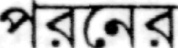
পরনের
